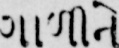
ગાળીને
